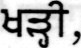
ਖੜ੍ਹੀ,
